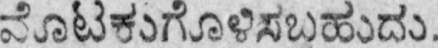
ಮೊಟಕುಗೊಳಿಸಬಹುದು.
